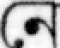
নে
